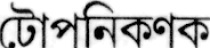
টোপনিকণক
